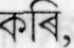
কৰি,
